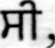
ਸੀ,
